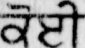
ਕੋਈ
